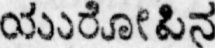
ಯುರೋಪಿನ
